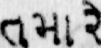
તમારે
